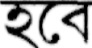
হবে
